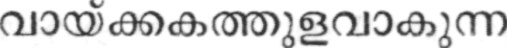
വായ്ക്കകത്തുളവാകുന്ന
